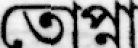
তোপ্না
